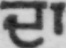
ਦਾ
